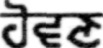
ਹੋਵਣ
